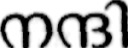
നന്ദി
